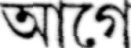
আগে
